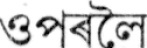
ওপৰলৈ
